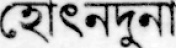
হোৎনদুনা
